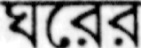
ঘরের
